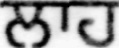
ਲਾਹ
